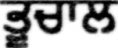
ਭੂਚਾਲ
